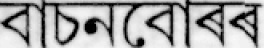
বাচনবোৰৰ
